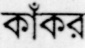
কাঁকর
